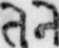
તેને
